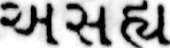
અસહ્ય
